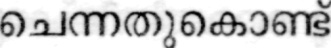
ചെന്നതുകൊണ്ട്
